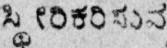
ಸ್ಥೀರಿಕರಿಸುವ
